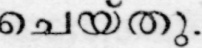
ചെയ്തു.
